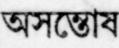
অসন্তোষ
